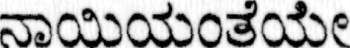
ನಾಯಿಯಂತೆಯೇ
